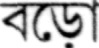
বড়ো
